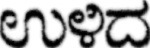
ಉಳಿದ
